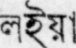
লইয়া
